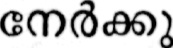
നേര്‍ക്കു
